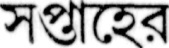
সপ্তাহের
